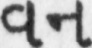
વન
